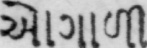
ઓગાળી
